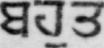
ਬਹੁਤ
